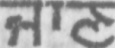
ਜਾਣ
